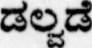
ಡಲ್ವಡೆ
